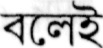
বলেই
